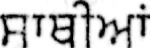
ਸਾਥੀਆਂ
